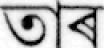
তাৰ
